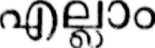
എല്ലാം
